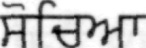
ਸੋਚਿਆ
